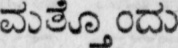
ಮತ್ತೊಂದು
